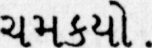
ચમકયો.
